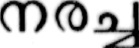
നരച്ച
